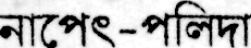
নাপেৎ-পলিদা
